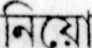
নিয়ো
